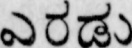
ಎರಡು
